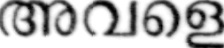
അവളെ
